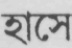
হাসে
